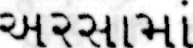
અરસામાં
